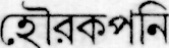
হৌরকপনি
